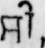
ਸੀ,
